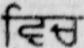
ਵਿਚ
